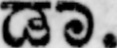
ಡಾ.
